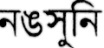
নঙসুনি
